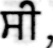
ਸੀ,
